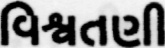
વિશ્વતણી
